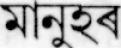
মানুহৰ
